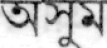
অসুম
